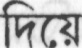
দিয়ে
